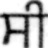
ਸੀ
